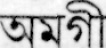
অমগী
